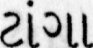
ટાંગા
